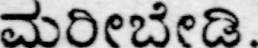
ಮರೀಬೇಡಿ.
